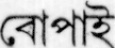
বোপাই
